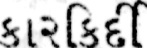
કારકિર્દી
